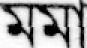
মমা
